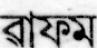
ৱাফম
